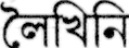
লৈখিনি
